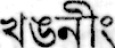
খঙনীং
